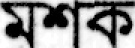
মশক
